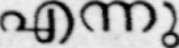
എന്നു
